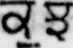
ਕੁਝ
